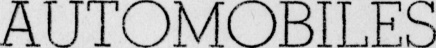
AUTOMOBILES
